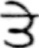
ਤੇ
